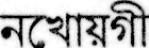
নখোয়গী
